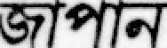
জাপান
